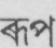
ৰূপ
